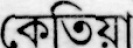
কেতিয়া
